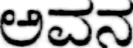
ಅವನ
